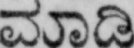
ಮಾಡಿ
